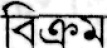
বিক্রম
